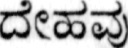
ದೇಹವು
